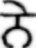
ਨੇ
